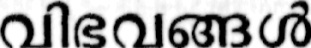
വിഭവങ്ങള്‍
